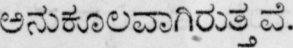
ಅನುಕೂಲವಾಗಿರುತ್ತವೆ.
